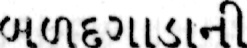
બળદગાડાની
